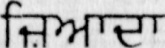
ਜ਼ਿਆਦਾ
